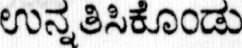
ಉನ್ನತಿಸಿಕೊಂಡು
